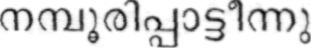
നമ്പൂരിപ്പാട്ടീന്നു
